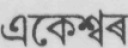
একেশ্বৰ
